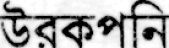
উরকপনি
